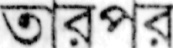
তারপর
